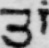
ਤਾਂ
